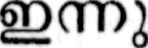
ഇന്നു
